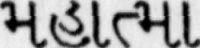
મહાત્મા
